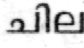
ചില
